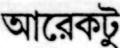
আরেকটু
